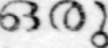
ഒരു
